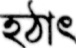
হঠাৎ
